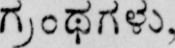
ಗ್ರಂಥಗಳು,
